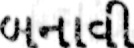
બનાવી
